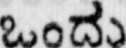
ಒಂದು
